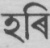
হৰি
